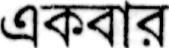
একবার
